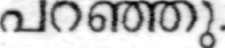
പറഞ്ഞു.
